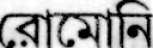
রোমোনি
